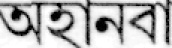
অহানবা
